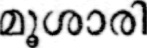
മൂശാരി
